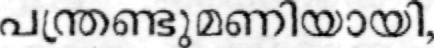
പന്ത്രണ്ടുമണിയായി,
